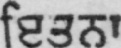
ਇਤਨਾ
